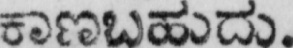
ಕಾಣಬಹುದು.
